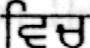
ਵਿਚ
